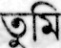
তুমি
